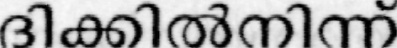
ദിക്കില്‍നിന്ന്
